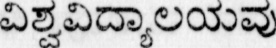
ವಿಶ್ವವಿದ್ಯಾಲಯವು
